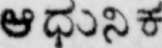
ಆಧುನಿಕ
